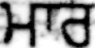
ਮਾਰ
